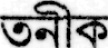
তনীক
